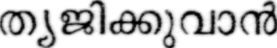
ത്യജിക്കുവാന്‍
